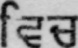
ਵਿਚ
